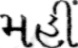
મહીં
